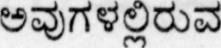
ಅವುಗಳಲ್ಲಿರುವ
